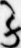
કે
